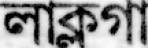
লাক্লগা
